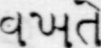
વખતે
